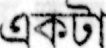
একটা
